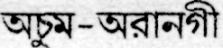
অচুম-অরানগী
